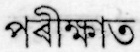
পৰীক্ষাত
